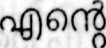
എന്റെ
